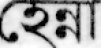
হেন্না
